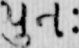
પુનઃ
